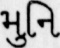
મુનિ
